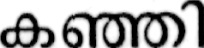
കഞ്ഞി
